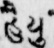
હૈયુ
